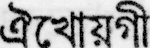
এখোয়গী
